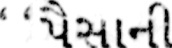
"પૈસાની
